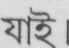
যাই
